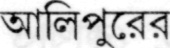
আলিপুরের
